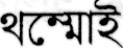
থম্মোই
